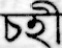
চহী
